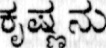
ಕೃಷ್ಣನು
